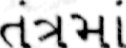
તંત્રમાં
